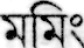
মমিং
